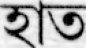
হাত
